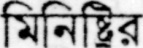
মিনিষ্ট্রির
